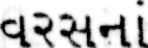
વરસનાં
